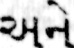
અને
